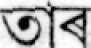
তাৰ
